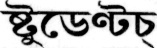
ষ্টুডেণ্টচ্‌
